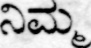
ನಿಮ್ಮ
